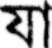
যা
